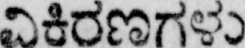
ವಿಕಿರಣಗಳು
